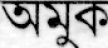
অমুক
